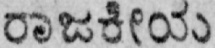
ರಾಜಕೀಯ
